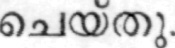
ചെയ്തു.
